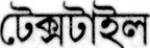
টেক্সটাইল
